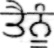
ਤੈਨੂੰ
